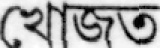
খোজত
